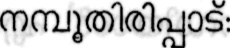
നമ്പൂതിരിപ്പാട്:
